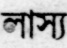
লাস্য
